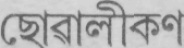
ছোৱালীকণ
